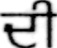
ਦੀ
